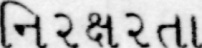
નિરક્ષરતા
